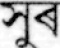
সুৰ
